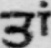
ਤਾਂ
